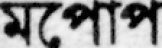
মপোপ
